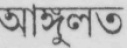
আঙ্গুলত
